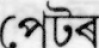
পেটৰ
